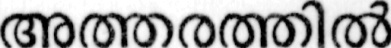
അത്തരത്തില്‍
